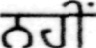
ਨਹੀਂ
